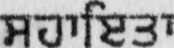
ਸਹਾਇਤਾ
